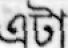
এটা
